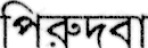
পিরুদবা
